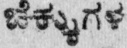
ಚೆಕ್ಕುಗಳ
